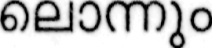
ലൊന്നും
